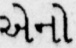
એનો
